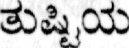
ತುಷ್ಟಿಯ
